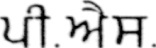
ਪੀ.ਐਸ.
